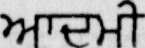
ਆਦਮੀ
